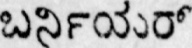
ಬರ್ನಿಯರ್
